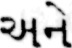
અને
